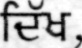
ਦਿੱਖ,
